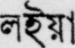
লইয়া
